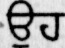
ਉਹ
